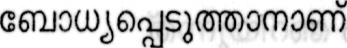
ബോധ്യപ്പെടുത്താനാണ്
